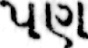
પણ
